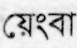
য়েংবা
